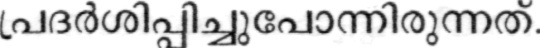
പ്രദര്‍ശിപ്പിച്ചുപോന്നിരുന്നത്.
